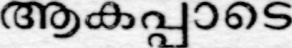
ആകപ്പാടെ
